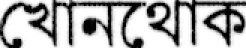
খোনথোক
